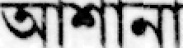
আশানা
